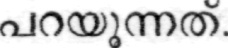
പറയുന്നത്.
